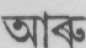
আৰু
